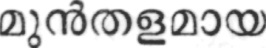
മുന്‍തളമായ
